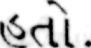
હતો.
